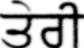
ਤੇਰੀ
